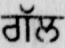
ਗੱਲ
